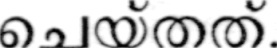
ചെയ്തത്.
